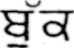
ਬੁੱਕ
